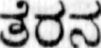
ತೆರನ
